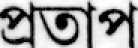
প্রতাপ
